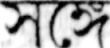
সঙ্গে
